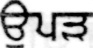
ਉਪੜ
